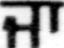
ਜਾ
